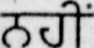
ਨਹੀਂ
